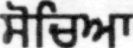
ਸੋਚਿਆ
